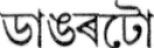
ডাঙৰটো
